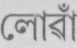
লোৱাঁ
